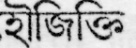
হৌজিক্তি
